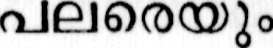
പലരെയും
